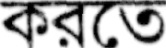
করতে
